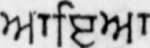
ਆਇਆ
